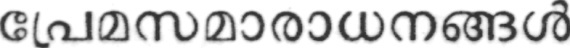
പ്രേമസമാരാധനങ്ങള്‍
